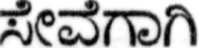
ಸೇವೆಗಾಗಿ
